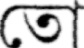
তো
